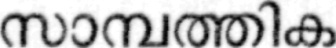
സാമ്പത്തിക
